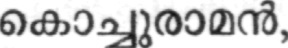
കൊച്ചുരാമന്‍,
